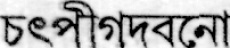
চৎপীগদবনো
